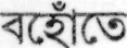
বহোঁতে
